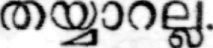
തയ്യാറല്ല.
